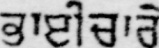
ਭਾਈਚਾਰੇ
